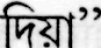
দিয়া"
